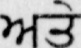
ਅਤੇ
